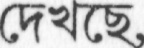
দেখছে,
